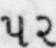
પર
